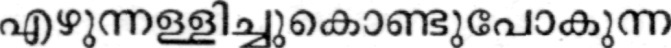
എഴുന്നള്ളിച്ചുകൊണ്ടുപോകുന്ന
